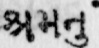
શ્રમનું
